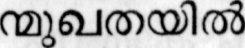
ന്മുഖതയില്‍
